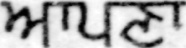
ਆਪਣਾ
